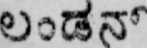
ಲಂಡನ್
